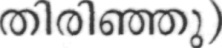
തിരിഞ്ഞു)
